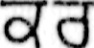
ਕਰ
